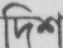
দিশ
